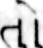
તો
